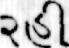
રહી
